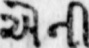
એની
